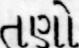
તણો
